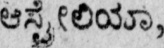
ಆಸ್ಟ್ರೇಲಿಯಾ,
